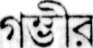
গম্ভীর
